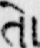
તો
